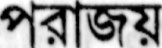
পরাজয়
